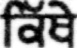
ਕਿੱਥੇ
